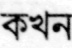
কখন
